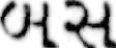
બસ
